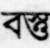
বস্তু
